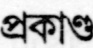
প্রকাণ্ড
